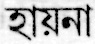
হায়না
